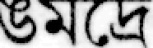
ঙমদ্রে
